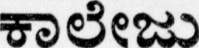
ಕಾಲೇಜು
